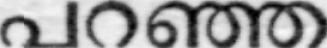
പറഞ്ഞ
